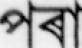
পৰা
